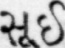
સૂઈ
